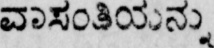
ವಾಸಂತಿಯನ್ನು
